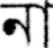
না
